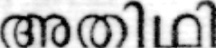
അതിഥി
